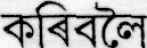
কৰিবলৈ
